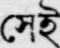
সেই
